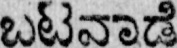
ಬಟವಾಡೆ
